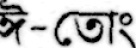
ঈ-তোং
